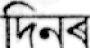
দিনৰ
